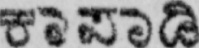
ಕಾಪಾಡಿ
